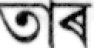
তাৰ
